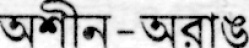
অশীন-অরাঙ
